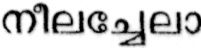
നീലച്ചേലാ
